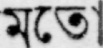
মতো
